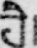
ਹੈ।
